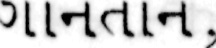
ગાનતાન,
